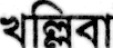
খল্লিবা
